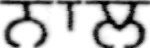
ਨਾਲ
